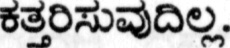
ಕತ್ತರಿಸುವುದಿಲ್ಲ.
